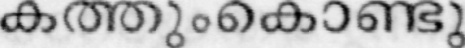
കത്തുംകൊണ്ടു
